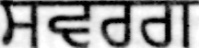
ਸਵਰਗ
